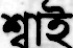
শ্বাই
